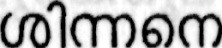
ശിന്നനെ
